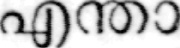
എന്താ
